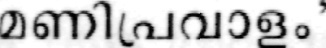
മണിപ്രവാളം'
